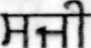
ਸਜੀ
